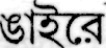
ঙাইরে
